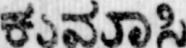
ಕುಮಾಸಿ
